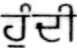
ਹੁੰਦੀ
